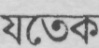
যতেক
